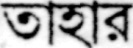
তাহার
